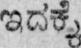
ಇದಕ್ಕೆ
